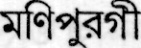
মণিপুরগী
